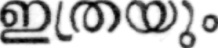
ഇത്രയും
